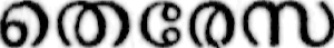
തെരേസ
